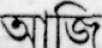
আজি
